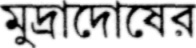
মুদ্রাদোষের
